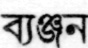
ব্যঞ্জন
